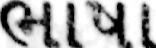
ભાષા
